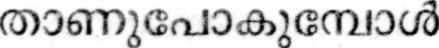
താണുപോകുമ്പോള്‍
